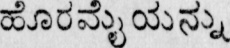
ಹೊರಮೈಯನ್ನು
